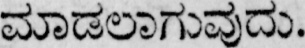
ಮಾಡಲಾಗುವುದು.
